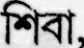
শিবা,
